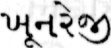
ખૂનરેજી
